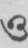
ও
